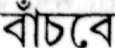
বাঁচবে
